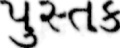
પુસ્તક
